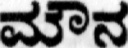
ಮೌನ
